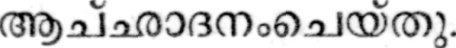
ആച്ഛാദനംചെയ്തു.
